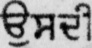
ਉਸਦੀ
